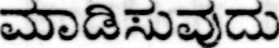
ಮಾಡಿಸುವುದು
